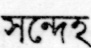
সন্দেহ
